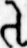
તે
